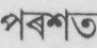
পৰশত
